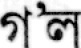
গ'ল
